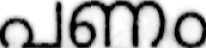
പണം
